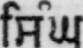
ਸਿੰਘ
